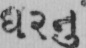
ધરનું
